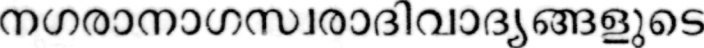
നഗരാനാഗസ്വരാദിവാദ്യങ്ങളുടെ
